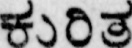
ಕುರಿತ
